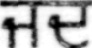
ਜਦ
